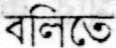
বলিতে
